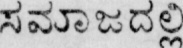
ಸಮಾಜದಲ್ಲಿ
